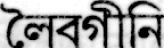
লৈবগীনি
